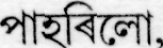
পাহৰিলো,
